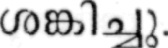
ശങ്കിച്ചു.
